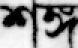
শঙ্গ
